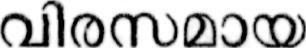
വിരസമായ
